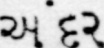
અંદર
